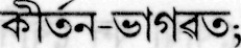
কীর্তন-ভাগৱত;
